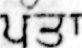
ਪੱਤਾ
